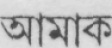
আমাক
